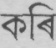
কৰি
